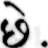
છે.
